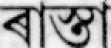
ৰাস্তা
